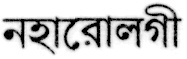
নহারোলগী
